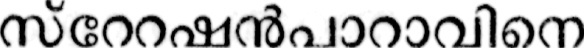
സ്റേറഷന്‍പാറാവിനെ
